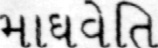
માધવેતિ
